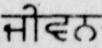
ਜੀਵਨ
